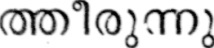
ത്തീരുന്നു
